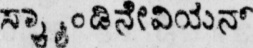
ಸ್ಕ್ಯಾಂಡಿನೇವಿಯನ್
